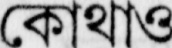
কোথাও
